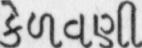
કેળવણી
